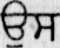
ਉਸ
